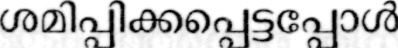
ശമിപ്പിക്കപ്പെട്ടപ്പോള്‍
